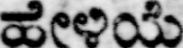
ಹೇಳಿಯೆ
